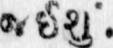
જઈશું.
